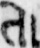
તો
